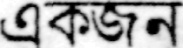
একজন
